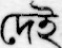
দেই
